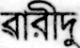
ৱারীদু
